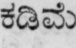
ಕಡಿಮೆ
